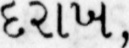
દરાખ,
